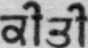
ਕੀਤੀ
